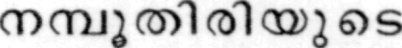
നമ്പൂതിരിയുടെ
